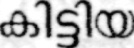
കിട്ടിയ
